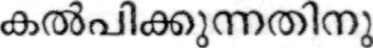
കല്‍പിക്കുന്നതിനു
